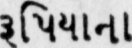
રૂપિયાના
